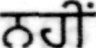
ਨਹੀਂ
